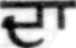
ਦਾ
